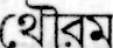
থৌরম
